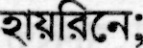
হায়রিনে;
